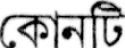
কোনটি
